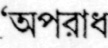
‘অপরাধ
